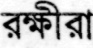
রক্ষীরা
